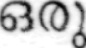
ഒരു
